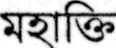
মহাক্তি
